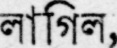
লাগিল,
